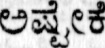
ಅಷ್ಟೇಕೆ
